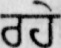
ਰਹੇ
